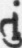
તું
